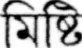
মিষ্টি
